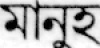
মানুহ
